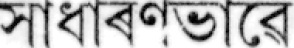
সাধাৰণভাৱে
